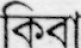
কিবা
